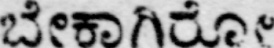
ಬೇಕಾಗಿರೋ
